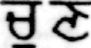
ਚੁਣ
